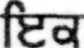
ਇਕ
